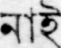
নাই
